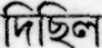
দিছিল
